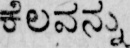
ಕೆಲವನ್ನು
